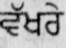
ਵੱਖਰੇ
